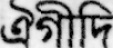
ঐগীদি
